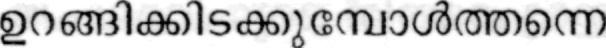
ഉറങ്ങിക്കിടക്കുമ്പോള്‍ത്തന്നെ
